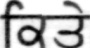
ਕਿਤੇ
